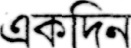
একদিন
